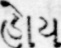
હોય
